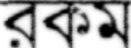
রকম
